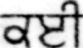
ਕਈ
